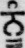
ਨੂੰ
